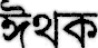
ঈথক
